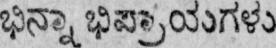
ಭಿನ್ನಾಭಿಪ್ರಾಯಗಳು
